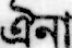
ঐনা
